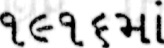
૧૯૧૬માં
